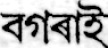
বগৰাই
